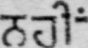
ਨਹੀਂ
